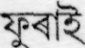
ফুৰাই
